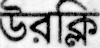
উরক্লি
